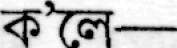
ক'লে-
